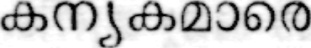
കന്യകമാരെ
